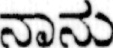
ನಾನು
